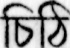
চিঠি
